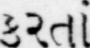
કરતાં
